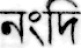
নংদি
